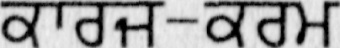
ਕਾਰਜ-ਕਰਮ
